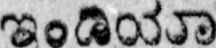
ಇಂಡಿಯಾ
